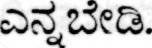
ಎನ್ನಬೇಡಿ.
